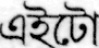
এইটো
